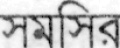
সমসির
